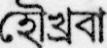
হৌখ্রবা
